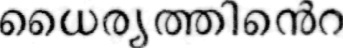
ധൈര്യത്തിന്റെ
